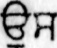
ਉਸ
